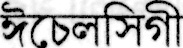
ঈচেলসিগী
